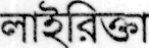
লাইরিক্তা
